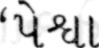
'પેશ્વા
